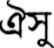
ঐসু
